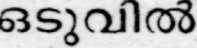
ഒടുവില്‍
